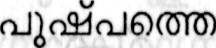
പുഷ്പത്തെ
